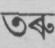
তৰু
